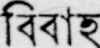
বিবাহ
